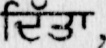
ਦਿੱਤਾ,
